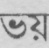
ভয়
